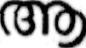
ആ
